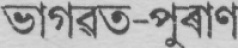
ভাগৱত-পুৰাণ,
